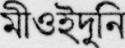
মীওইদুনি
